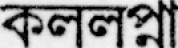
কললপ্না
